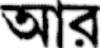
আর
